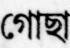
গোছা
